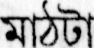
মাঠটা
